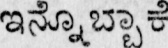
ಇನ್ನೊಬ್ಬಾಕೆ
